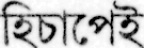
হিচাপেই
